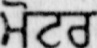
ਮੋਟਰ
